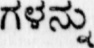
ಗಳನ್ನು
